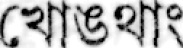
খোঙথাং
